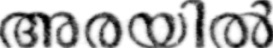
അരയില്‍
